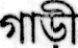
গাড়ী
